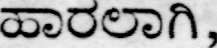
ಹಾರಲಾಗಿ,
